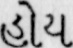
હોય
